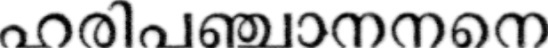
ഹരിപഞ്ചാനനനെ
